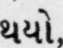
થયો,
